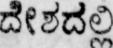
ದೇಶದಲ್ಲಿ
